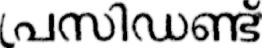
പ്രസിഡണ്ട്
